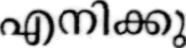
എനിക്കു
